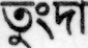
তুংদা
